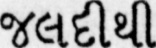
જલદીથી
